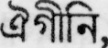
ঐগীনি,
